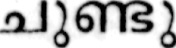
ചുണ്ടു
